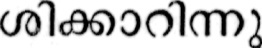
ശിക്കാറിന്നു
